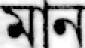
মান
